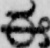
ಈ
